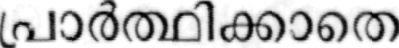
പ്രാര്‍ത്ഥിക്കാതെ
